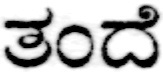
ತಂದೆ
